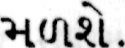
મળશે.
